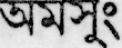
অমসুং
